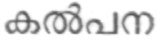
കല്‍പന
